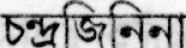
চন্দ্রজিনিনা
